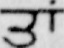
ਤਾਂ
